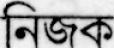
নিজক
